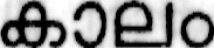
കാലം
